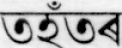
তহঁতৰ
